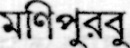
মণিপুরবু
